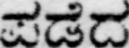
ಪಡೆದ
